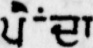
ਪੈਂਦਾ
